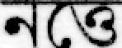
নত্তে
